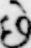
છે
